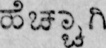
ಹೆಚ್ಚಾಗಿ
